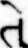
તે
